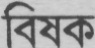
বিষক
